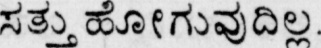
ಸತ್ತುಹೋಗುವುದಿಲ್ಲ.
